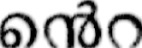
ന്റെ
